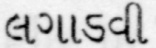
લગાડવી
